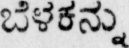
ಬೆಳಕನ್ನು
